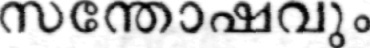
സന്തോഷവും
